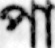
পা
